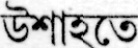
উশাহতে
